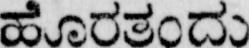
ಹೊರತಂದು
